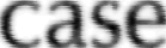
case
